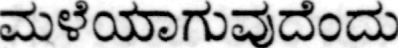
ಮಳೆಯಾಗುವುದೆಂದು
